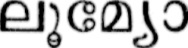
ലൂമ്യോ
